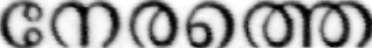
നേരത്തെ
